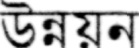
উন্নয়ন
